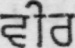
ਵੀਰ
